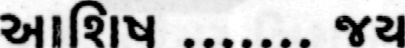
આશિષ.......જય
